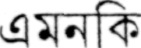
এমনকি
